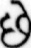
છે
